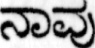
ನಾವು
